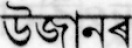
উজানৰ
